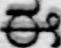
ಈ
